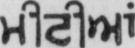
ਮੀਟੀਆਂ
